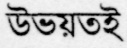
উভয়তই
